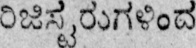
ರಿಜಿಸ್ಟರುಗಳಿಂದ
